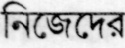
নিজেদের
